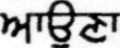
ਆਉਣਾ
